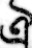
ঐ
